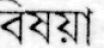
বিষয়া
